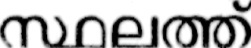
സ്ഥലത്ത്
